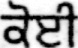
ਕੋਈ
